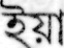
ইয়া
